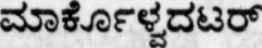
ಮಾರ್ಕೊಳ್ವದಟರ್
